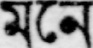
মনে
